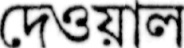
দেওয়াল
